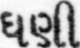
ઘણી
